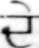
ਦੇ
